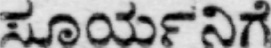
ಸೂರ್ಯನಿಗೆ
